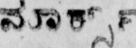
ಮಾರ್ಕ್ಸ್
